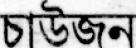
চাউজন
